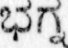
ಭಗ್ನ
